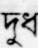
দুধ
